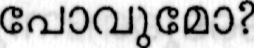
പോവുമോ?
